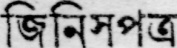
জিনিসপত্র
